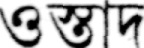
ওস্তাদ
